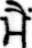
ਮੈਂ
